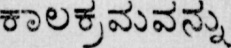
ಕಾಲಕ್ರಮವನ್ನು
